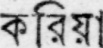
করিয়া
